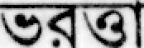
ভারত্তা
